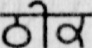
ਠੀਕ
